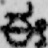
ಈ
